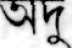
অদু
